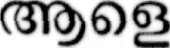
ആളെ
